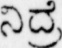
ನಿದ್ರೆ
